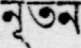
নূতন
